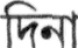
দিনা
